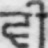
ਵੀ
